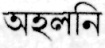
অহলনি
